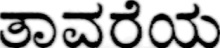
ತಾವರೆಯ
